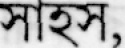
সাহস,
